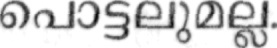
പൊട്ടലുമല്ല.
